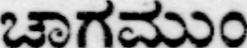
ಚಾಗಮುಂ
